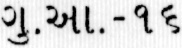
ગુ.આ.-૧૬.
